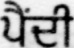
ਪੈਂਦੀ
